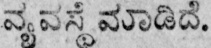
ವ್ಯವಸ್ಥೆಮಾಡಿದೆ.
